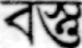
বস্তু
